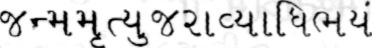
જન્મમૃત્યુજરાવ્યાધિભયં
